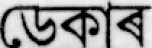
ডেকাৰ
